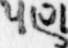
પણ
